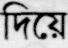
দিয়ে
